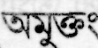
অমুক্তং
